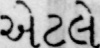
એટલે
